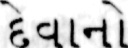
દેવાનો
